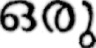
ഒരു
